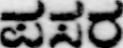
ಪಸರ
